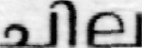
ചില
